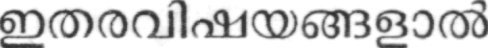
ഇതരവിഷയങ്ങളാല്‍
